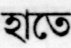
হাতে
